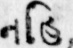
નહિ,
